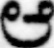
ಆ
